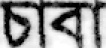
চাবা
